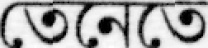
তেনেতে
